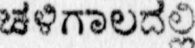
ಚಳಿಗಾಲದಲ್ಲಿ
